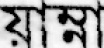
য়াম্না
